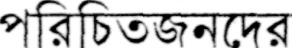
পরিচিতজনদের
